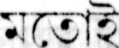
মতোই
